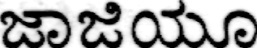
ಜಾಜಿಯೂ
